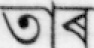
তাৰ
